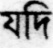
যদি
